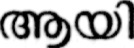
ആയി
